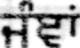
ਜੰਞਾਂ
